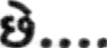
છે.........
